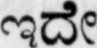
ಇದೇ
